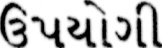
ઉપયોગી
